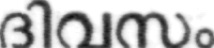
ദിവസം
